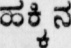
ಹಕ್ಕಿನ
